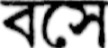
বসে
